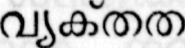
വ്യക്തത
